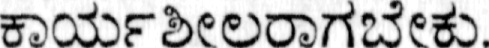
ಕಾರ್ಯಶೀಲರಾಗಬೇಕು.
